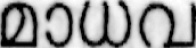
മാധവ
